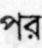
পর
